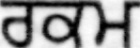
ਰਕਮ
